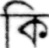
কি
